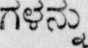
ಗಳನ್ನು
